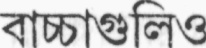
বাচ্চাগুলিও
